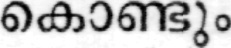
കൊണ്ടും
